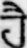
ਹੈ
